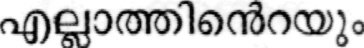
എല്ലാത്തിന്റെയും
